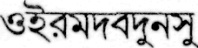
ওইরমদবদুনসু
